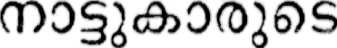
നാട്ടുകാരുടെ
